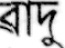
ৱাদু
